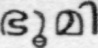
ഭൂമി
